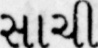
સાચી
